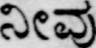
ನೀವು
